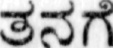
ತನಗೆ
